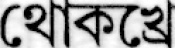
থোকখ্রে
